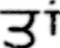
ਤਾਂ
